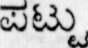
ಪಟ್ಟು
